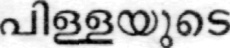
പിള്ളയുടെ
